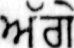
ਅੱਗੇ
